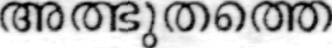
അത്ഭുതത്തെ
